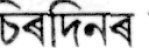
চিৰদিনৰ
